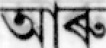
আৰু
